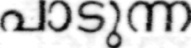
പാടുന്ന
